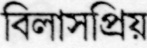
বিলাসপ্রিয়
